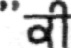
''ਕੀ
